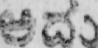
ಅದು
